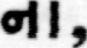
ના,
